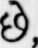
છે,
